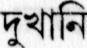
দুখানি
